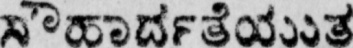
ಸೌಹಾರ್ದತೆಯುತ
